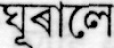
ঘূৰালে
